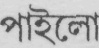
পাইলো
